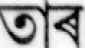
তাৰ
